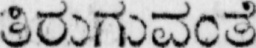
ತಿರುಗುವಂತೆ
